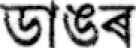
ডাঙৰ
